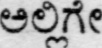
ಅಲ್ಲಿಗೇ
